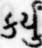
કર્યુ
